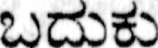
ಬದುಕು
